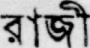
রাজী
